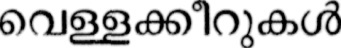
വെള്ളക്കീറുകള്‍
